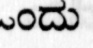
ಒ೦ದು
